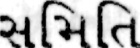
સમિતિ
